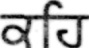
ਕਹਿ
